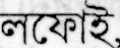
লফোই,
